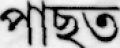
পাছত
